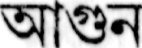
আগুন
